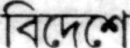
বিদেশে
